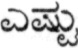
ಎಷ್ಟು
